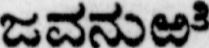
ಜವನುಱೆ
